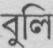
বুলি
